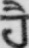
ਹੈ
